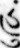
હું
